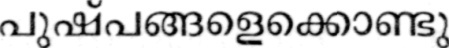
പുഷ്പങ്ങളെക്കൊണ്ടു
